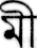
মী
